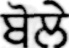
ਬੋਲੇ
